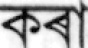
কৰা
